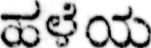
ಹಳೆಯ
